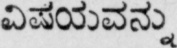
ವಿಷಯವನ್ನು
